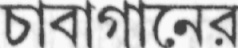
চাবাগানের
